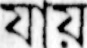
যায়
